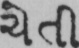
ચેતી
